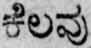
ಕೆಲವು
